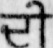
ਦੀ
